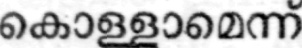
കൊള്ളാമെന്ന്
